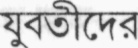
যুবতীদের
